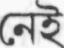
নেই
